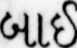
બાઈ
